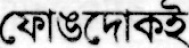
ফোঙদোকই
